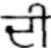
ਦੀ
